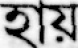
হায়
